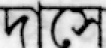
দাসে
